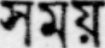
সময়
